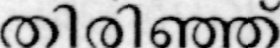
തിരിഞ്ഞ്
